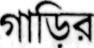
গাড়ির
